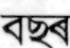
বছৰ
